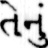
તેનું
